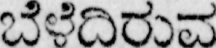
ಬೆಳೆದಿರುವ
